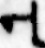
ન
